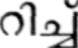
റിച്ച്
